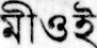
মীওই
